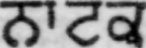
ਨਾਟਕ
